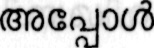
അപ്പോള്‍
